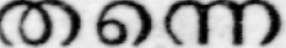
തന്നെ
